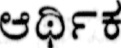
ಆರ್ಥಿಕ
